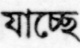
যাচ্ছে
